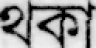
থকা
